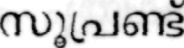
സൂപ്രണ്ട്
